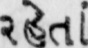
રહેતાં
